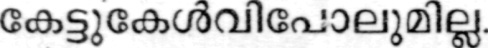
കേട്ടുകേള്‍വിപോലുമില്ല.
